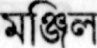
মঞ্জিল
